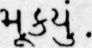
મૂકયું.
